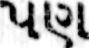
પણ
